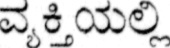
ವ್ಯಕ್ತಿಯಲ್ಲಿ
